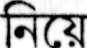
নিয়ে
